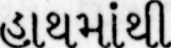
હાથમાંથી
